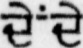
ਦੇਂਦੇ
